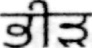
ਭੀੜ
